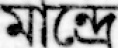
মান্দ্রে
